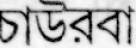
চাউরবা
